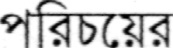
পরিচয়ের
